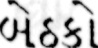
બેઠકો
